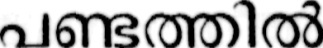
പണ്ടത്തില്‍
